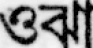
ওঝা
